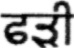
ਫੜੀ
